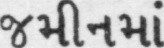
જમીનમાં
